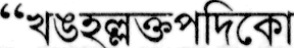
“খঙহল্লক্তপদিকো
